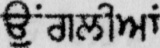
ਉਂਗਲੀਆਂ
